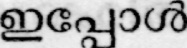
ഇപ്പോള്‍
